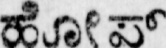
ಹೋಪ್
